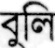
বুলি
